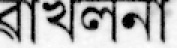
ৱাখলনা
